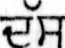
ਦੱਸ
